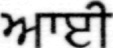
ਆਈ
